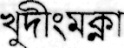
খুদীংমক্না
